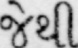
જેથી
